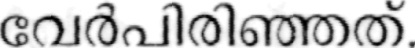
വേര്‍പിരിഞ്ഞത്.
